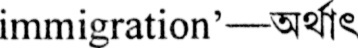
immigration'-অর্থাৎ
